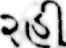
રહી
